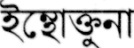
ইন্থোক্তুনা
